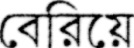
বেরিয়ে
